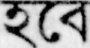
হবে
